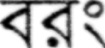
বরং
